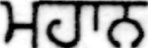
ਮਹਾਨ
